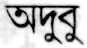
অদুবু
